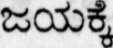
ಜಯಕ್ಕೆ
